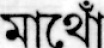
মাথোঁ
